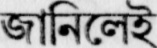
জানিলেই
